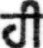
ਹੀ
